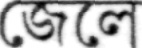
জেলে
